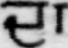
ਦਾ
